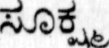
ಸೂಕ್ಷ್ಮ
